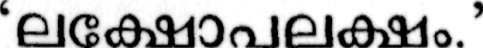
‘ലക്ഷോപലക്ഷം.’
